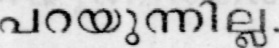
പറയുന്നില്ല.
